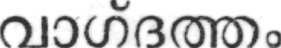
വാഗ്ദത്തം
